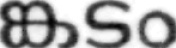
ങ്കടം
